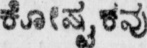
ಕೋಷ್ಟಕವು
